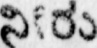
ನೀರು
